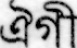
ঐগী
